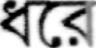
ধরে
